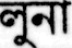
লুনা
